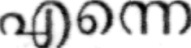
എന്നെ
